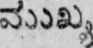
ಮುಖ್ಯ
